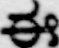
ಈ
